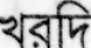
খরদি
